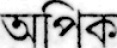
অপিক
